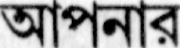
আপনার
